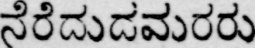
ನೆರೆದುದಮರರು
